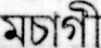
মচাগী
